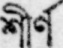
শীর্ণ
